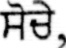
ਸੋਚੇ,
